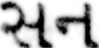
સન
